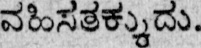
ವಹಿಸತಕ್ಕುದು.
